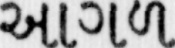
આગળ
